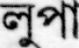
লুপা
